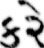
કરે
